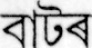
বাটৰ
